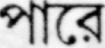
পারে
